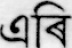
এৰি
